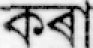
কৰা
